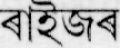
ৰাইজৰ
